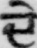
ਦੇ
